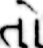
તો
